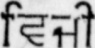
ਵਿਜੀ
